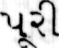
પૂરી
